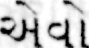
એવો
